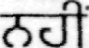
ਨਹੀਂ
